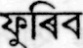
ফুৰিব
